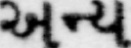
અન્ય
